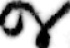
જ
